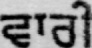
ਵਾਰੀ
